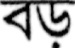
বড়
